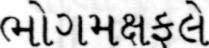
ભોગમક્ષફલે
